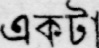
একটা
